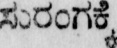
ಸುರಂಗಕ್ಕೆ
